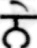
ਨੇ
